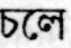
চলে
